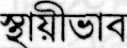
স্থায়ীভাব
